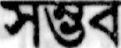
সম্ভব
